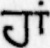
ਹਾਂ
